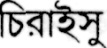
চিরাইসু
